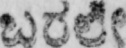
ಬರಲೇ
